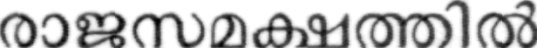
രാജസമക്ഷത്തില്‍
